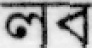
লব
